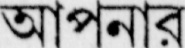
আপনার
